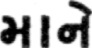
માને
